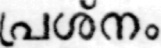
പ്രശ്നം
